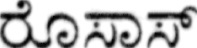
ರೊಸಾಸ್
